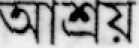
আশ্রয়
